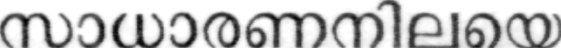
സാധാരണനിലയെ
